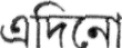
এদিনো
